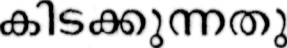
കിടക്കുന്നതു
